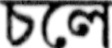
চলে
